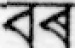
বৰ
